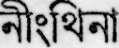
নীংথিনা
